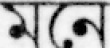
মনে
